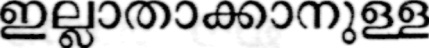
ഇല്ലാതാക്കാനുള്ള
